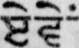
ਏਵੇਂ
